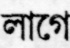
লাগে
